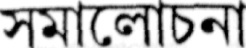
সমালোচনা
